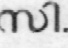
സി.
